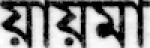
য়ায়মা
